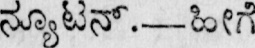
ನ್ಯೂಟನ್.-ಹೀಗೆ
